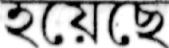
হয়েছে
